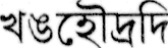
খঙহৌদ্রদি
